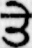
ਤੇ
